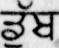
ਡੁੱਬ
